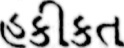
હકીકત
